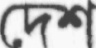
দেশ
